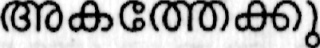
അകത്തേക്കു
